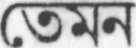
তেমন
